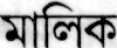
মালিক
